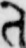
તે
